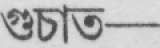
গুচাত-
